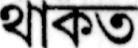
থাকত
